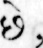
છે,
